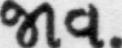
જાવ.
